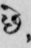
છે,
